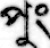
পুং
